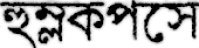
হুম্লকপসে
